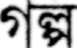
গল্প
